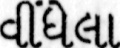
વીંધેલા
